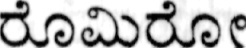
ರೊಮಿರೋ
